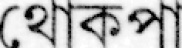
থোকপা
